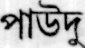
পাউদু
